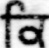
ਕਿ
